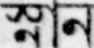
স্নান
